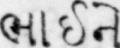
ભાઈને
